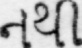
નથી
